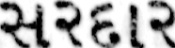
સરદાર
